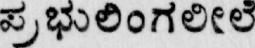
ಪ್ರಭುಲಿಂಗಲೀಲೆ
